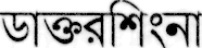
ডাক্তরশিংনা
